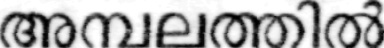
അമ്പലത്തില്‍
